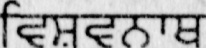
ਵਿਸ਼ਵਨਾਥ
